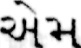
એમ
